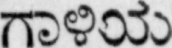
ಗಾಳಿಯ
